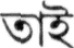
তাই
